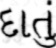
દાતું
